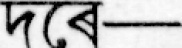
দৰে-
